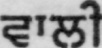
ਵਾਲੀ
